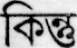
কিন্তু
